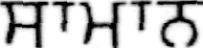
ਸਾਮਾਨ
